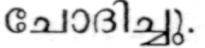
ചോദിച്ചു.
